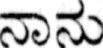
ನಾನು
